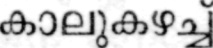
കാലുകഴച്ച്
